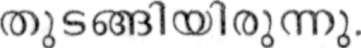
തുടങ്ങിയിരുന്നു.
